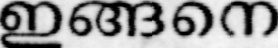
ഇങ്ങനെ
